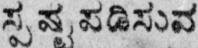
ಸ್ಪಷ್ಟಪಡಿಸುವ
